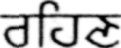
ਰਹਿਣ
